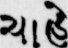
ચાહે
